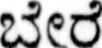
ಬೇರೆ
